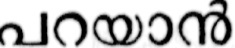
പറയാന്‍
